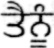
ਤੈਨੂੰ
